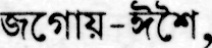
জগোয়-ঈশৈ,
